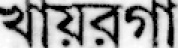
খায়রগা
